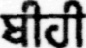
ਬੀਹੀ
